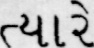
ત્યારે
